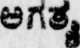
ಅಗತ್ಯ
